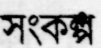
সংকল্প
